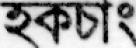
হকচাং
